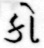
કો
